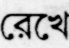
রেখে
